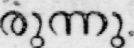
രുന്നു.
